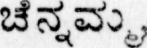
ಚೆನ್ನಮ್ಮ,
